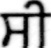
ਸੀ
